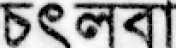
চৎলবা
